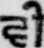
ਵੀ
